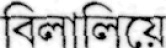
বিলালিয়ে
